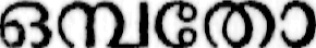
ഒമ്പതോ
